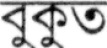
বুকুত
